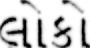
લોકો
